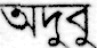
অদুবু
